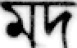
মদ
